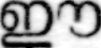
ഈ
